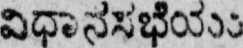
ವಿಧಾನಸಭೆಯು
